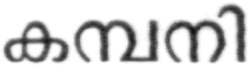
കമ്പനി
